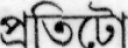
প্রতিটো
